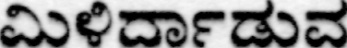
ಮಿಳಿರ್ದಾಡುವ
